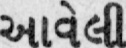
આવેલી
